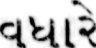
વધારે
